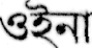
ওইনা
